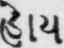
હોય
